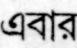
এবার
